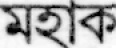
মহাক
